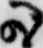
જે
